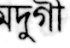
মদুগী
